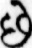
છે
